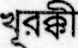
খূরক্কী
